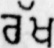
ਰੱਖ
